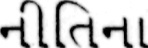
નીતિના
